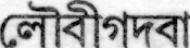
লৌবীগদবা
